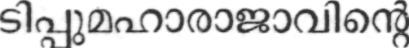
ടിപ്പുമഹാരാജാവിന്റെ
